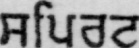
ਸਪਿਰਟ
